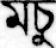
মচু
